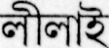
লীলাই
